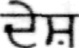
ਦੇਸ਼
